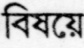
বিষয়ে
